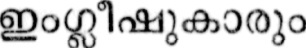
ഇംഗ്ലീഷുകാരും
